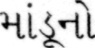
માંડૂનો
